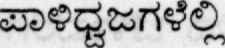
ಪಾಳಿಧ್ವಜಗಳೆಲ್ಲಿ
